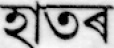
হাতৰ
